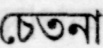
চেতনা
